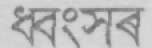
ধ্বংসৰ
